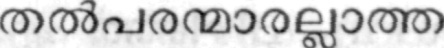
തല്‍പരന്മാരല്ലാത്ത
